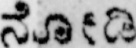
ನೋಡಿ
